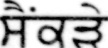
ਸੈਂਕੜੇ
